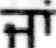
ਜਾਂ
